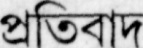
প্রতিবাদ
